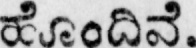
ಹೊಂದಿವೆ.
